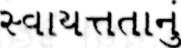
સ્વાયત્તતાનું
